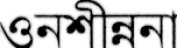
ওনশীন্ননা
